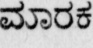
ಮಾರಕ
